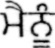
ਮੈਨੂੰ
